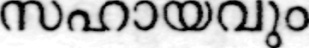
സഹായവും
